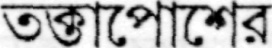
তক্তাপোশের
